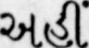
અહીં
